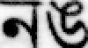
নঙ
